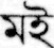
মই
